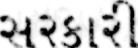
સરકારી
